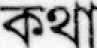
কথা
